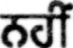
ਨਹੀਂ
